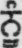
ਨੂੰ
